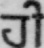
ਹੀ
